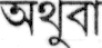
অথুবা
